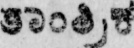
ತಾಂತ್ರಿಕ
